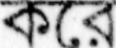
করে
